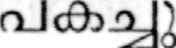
പകച്ചു
